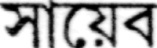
সায়েব
